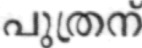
പുത്രന്
